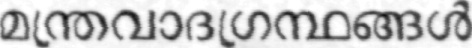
മന്ത്രവാദഗ്രന്ഥങ്ങള്‍
